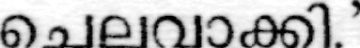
ചെലവാക്കി.’
